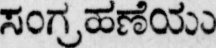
ಸಂಗ್ರಹಣೆಯು
